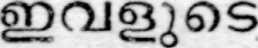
ഇവളുടെ
